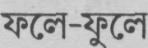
ফলে-ফুলে
